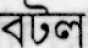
বটল
